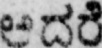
ಆದರೆ
